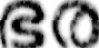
ഭര
